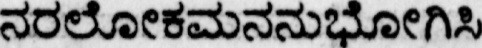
ನರಲೋಕಮನನುಭೋಗಿಸಿ
